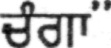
ਚੰਗਾ''
